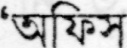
‘অফিস
